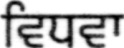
ਵਿਧਵਾ
